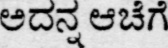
ಅದನ್ನಆಚೆಗೆ
